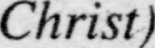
Christ)
